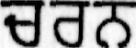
ਚਰਨ
